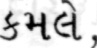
કમલે,
